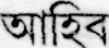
আহিব
